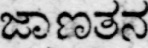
ಜಾಣತನ
